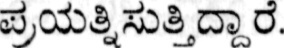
ಪ್ರಯತ್ನಿಸುತ್ತಿದ್ದಾರೆ.
